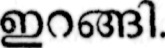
ഇറങ്ങി.
